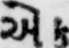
એક
